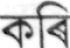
কৰি
